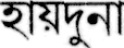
হায়দুনা
